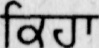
ਕਿਹਾ
